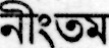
নীংতম
